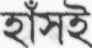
হাঁসই
